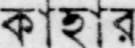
কাহার
